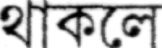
থাকলে
